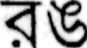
রঙ
